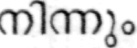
നിന്നും
